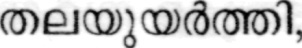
തലയുയര്‍ത്തി,
